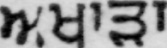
ਅਖਾੜਾ
